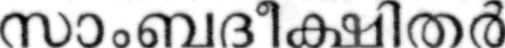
സാംബദീക്ഷിതര്‍
